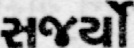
સજર્યો
